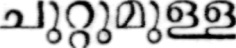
ചുറ്റുമുള്ള
